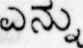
ಎನ್ನು
